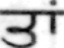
ਤਾਂ
